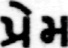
પ્રેમ
